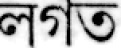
লগত
